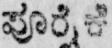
ಪೂರೈಕೆ
